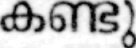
കണ്ടു
